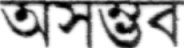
অসম্ভব
